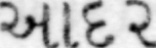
આદર
